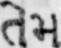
તેમ
